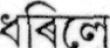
ধৰিলে
